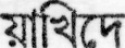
য়াখিদে
